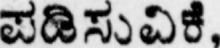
ಪಡಿಸುವಿಕೆ,
